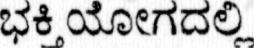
ಭಕ್ತಿಯೋಗದಲ್ಲಿ
